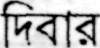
দিবার
